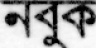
নবুক
